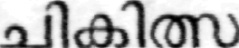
ചികിത്സ
